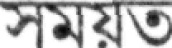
সময়ত
